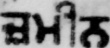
ਜ਼ਮੀਨ
